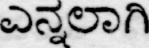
ಎನ್ನಲಾಗಿ
